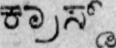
ಕ್ರಾಸ್ಡ್
